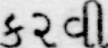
કરવી
